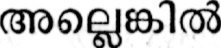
അല്ലെങ്കില്‍
